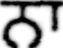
ਨਾ
